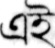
এই
